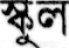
স্কুল
